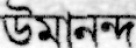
উমানন্দ
